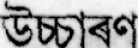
উচ্চাৰণ
